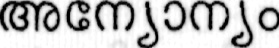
അന്യോന്യം
